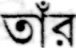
তাঁর
